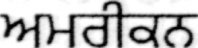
ਅਮਰੀਕਨ
